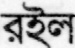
রইল
